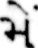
મેં
